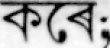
কৰে;
